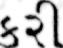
કરી
